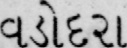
વડોદરા
